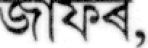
জাফৰ,
